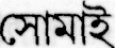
সোমাই
